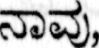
ನಾವು,
